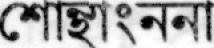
শোন্থাংননা
